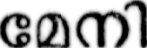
മേനി
